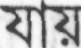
যায়
